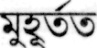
মুহূর্তত
